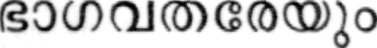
ഭാഗവതരേയും
